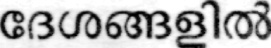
ദേശങ്ങളില്‍
